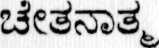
ಚೇತನಾತ್ಮ
